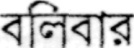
বলিবার
